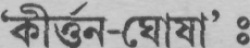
'কীৰ্ত্তন-ঘোষা'ঃ
